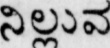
ನಿಲ್ಲುವ
